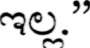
ಇಲ್ಲ."
